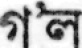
গ'ল
